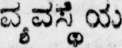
ವ್ಯವಸ್ಥೆಯ
